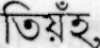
তিয়ঁহ,
